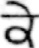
ਕੇ
